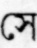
সে
